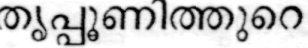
തൃപ്പൂണിത്തുറെ
